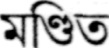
মণ্ডিত
